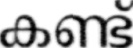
കണ്ട്
